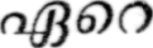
ഏറെ
